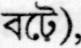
বটে),
